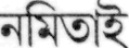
নমিতাই
